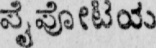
ಪೈಪೋಟಿಯ
